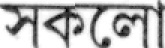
সকলো
